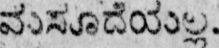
ಮಸೂದೆಯಲ್ಲ.
